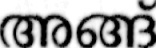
അങ്ങ്
